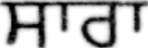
ਸਾਰਾ
